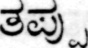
ತಪ್ಪು
